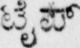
ಟೈಪ್
